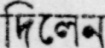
দিলেন
